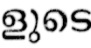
ളുടെ
